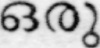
ഒരു
